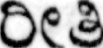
ರೀತಿ
